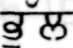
ਭੁੱਲ
